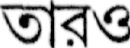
তারও
